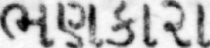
ભણકારા
